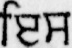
ਇਸ
